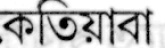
কেতিয়াবা
